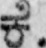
ಕೆ.
